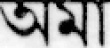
অমা
